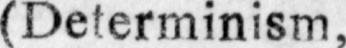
(Determinism,
